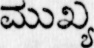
ಮುಖ್ಯ
